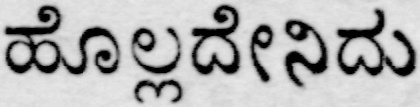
ಹೊಲ್ಲದೇನಿದು
